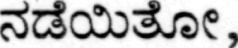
ನಡೆಯಿತೋ,
